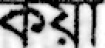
কয়া
